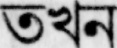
তখন
